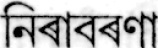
নিৰাবৰণা
